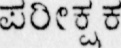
ಪರೀಕ್ಷಕ
